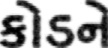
કોડને
